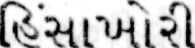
હિંસાખોરી
